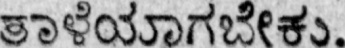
ತಾಳೆಯಾಗಬೇಕು.
